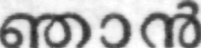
ഞാന്‍
